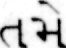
તમે
